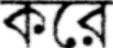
করে
